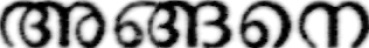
അങ്ങനെ
